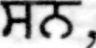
ਸਨ,
